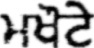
ਮਖੌਟੇ
